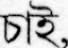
চাই,
